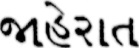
જાહેરાત
